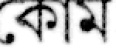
কোম
